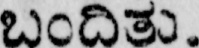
ಬಂದಿತು.
